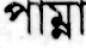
পাম্না
